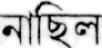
নাছিল
